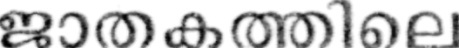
ജാതകത്തിലെ
